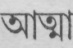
আত্মা
